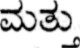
ಮತ್ತು
